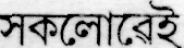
সকলোৱেই
